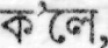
ক'লে,
